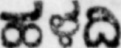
ಹಳದಿ
